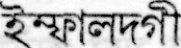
ইম্ফালদগী
